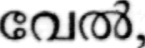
വേല്‍,
